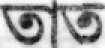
তাত
